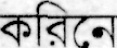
করিনে
